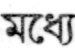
মধ্যে
